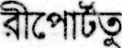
রীপোর্টতু
